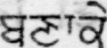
ਬਣਾਕੇ
